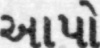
આપો
